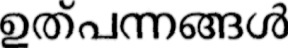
ഉത്പന്നങ്ങള്‍
